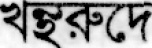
খন্থরুদে
